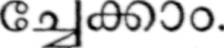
ച്ചേക്കാം.
